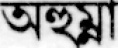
অহুম্না
